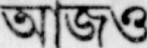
আজও
